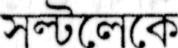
সল্টলেকে
